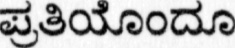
ಪ್ರತಿಯೊಂದೂ
